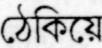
ঠেকিয়ে
